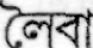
লৈবা
